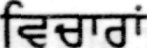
ਵਿਚਾਰਾਂ
